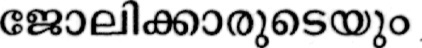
ജോലിക്കാരുടെയും
